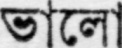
ভালো
